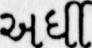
અર્ધી
